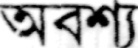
অবশ্য
